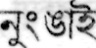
নুংঙাই
